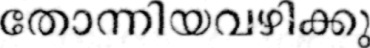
തോന്നിയവഴിക്കു
